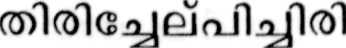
തിരിച്ചേല്പിച്ചിരി
